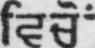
ਵਿਚੋਂ
